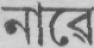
নাৱে
